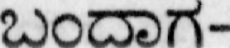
ಬಂದಾಗ-
